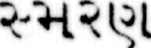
સ્મરણ
